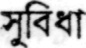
সুবিধা
